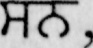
ਸਨ,
